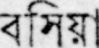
বসিয়া
